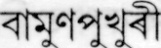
বামুণপুখুৰী
